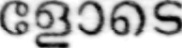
ളോടെ
